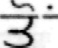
ਤੋਂ
